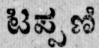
ಟಿಪ್ಪಣಿ
